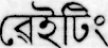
ৱেইটিং
